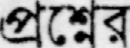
প্রশ্নের
